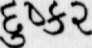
દુષ્કર
